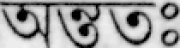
অন্ততঃ
